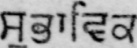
ਸੁਭਾਵਿਕ
